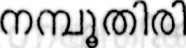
നമ്പൂതിരി
